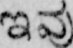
ಇವು
